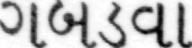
ગબડવા
